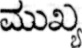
ಮುಖ್ಯ
